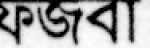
ফজবা
